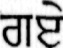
ਗਏ
